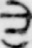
ਤੇ
